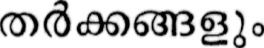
തര്‍ക്കങ്ങളും
